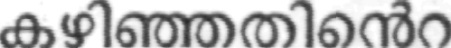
കഴിഞ്ഞതിന്റെ
